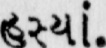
હસ્યાં.
